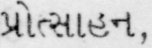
પ્રોત્સાહન,
